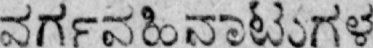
ವರ್ಗವಹಿವಾಟುಗಳ
